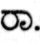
ರಾ.
